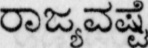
ರಾಜ್ಯವಷ್ಟೆ
